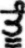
ਤੂੰ
